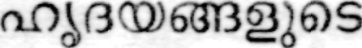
ഹൃദയങ്ങളുടെ
